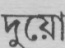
দুয়ো
